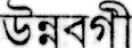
উন্নবগী
